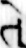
તે
